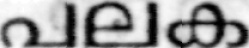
പലക
